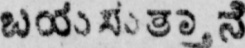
ಬಯಸುತ್ತಾನೆ
